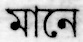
মানে
